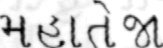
મહાતેજા
